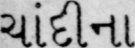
ચાંદીના
